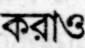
করাও
